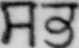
ਸਭ
